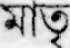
মাতৃ
